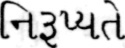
નિરૂપ્યતે
